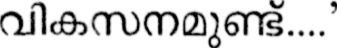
വികസനമുണ്ട്....’
